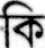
কি
